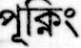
পূক্নিং
